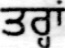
ਤਰ੍ਹਾਂ
